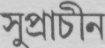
সুপ্রাচীন
